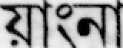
য়াংনা
